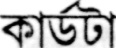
কার্ডটা
